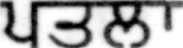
ਪਤਲਾ
